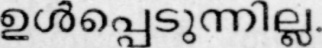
ഉള്‍പ്പെടുന്നില്ല.
